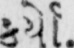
કર્યો.
